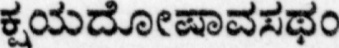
ಕ್ಷಯದೋಷಾವಸಥಂ
